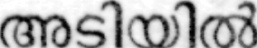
അടിയില്‍
